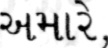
અમારે,
